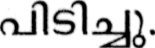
പിടിച്ചു.
